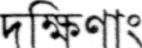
দক্ষিণাং
